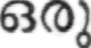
ഒരു
